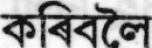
কৰিবলৈ
